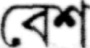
বেশ
